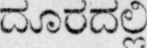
ದೂರದಲ್ಲಿ
